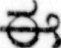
ಈ
